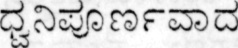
ಧ್ವನಿಪೂರ್ಣವಾದ
